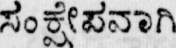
ಸಂಕ್ಷೇಪವಾಗಿ
